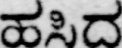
ಹಸಿದ
